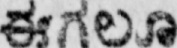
ಈಗಲೂ
